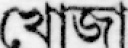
খোজা
